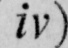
(iv)
